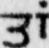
ਤਾਂ
